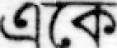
একে
